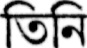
তিনি
